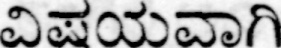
ವಿಷಯವಾಗಿ
